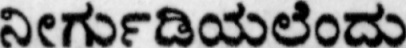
ನೀರ್ಗುಡಿಯಲೆಂದು
